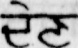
ਦੇਣ
